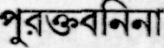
পুরক্তবনিনা
